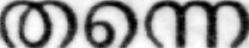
തന്നെ
